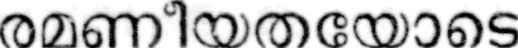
രമണീയതയോടെ
